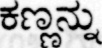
ಕಣ್ಣನ್ನು
